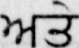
ਅਤੇ
